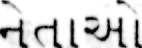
નેતાઓ
